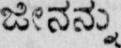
ಜೀನನ್ನು
